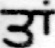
ਤਾਂ
